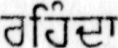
ਰਹਿੰਦਾ
